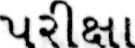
પરીક્ષા
